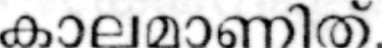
കാലമാണിത്.
